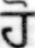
ਹੋ
